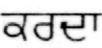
ਕਰਦਾ
